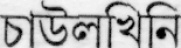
চাউলখিনি
